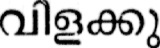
വിളക്കു
